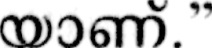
യാണ്.”
